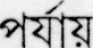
পর্যায়
